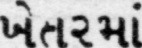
ખેતરમાં
